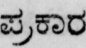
ಪ್ರಕಾರ
